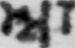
ਆ
